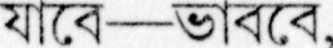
যাবে–ভাববে,
